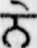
ਨੇ
